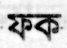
ফক
